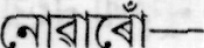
নোৱাৰোঁ-
